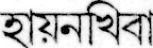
হায়নখিবা
